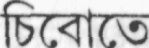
চিবোতে
